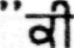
''ਕੀ
